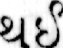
થઈ
